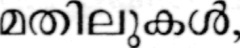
മതിലുകള്‍,
